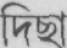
দিছা
